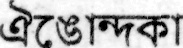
ঐঙোন্দকা
